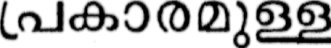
പ്രകാരമുള്ള
